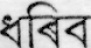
ধৰিব
